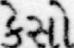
કેસો
